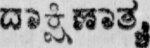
ದಾಕ್ಷಿಣಾತ್ಯ
